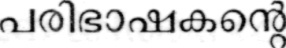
പരിഭാഷകന്റെ
